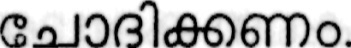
ചോദിക്കണം.
